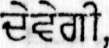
ਦੇਵੇਗੀ,
